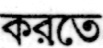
করতে
